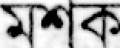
মশক
